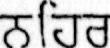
ਨਹਿਰ
